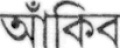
আঁকিব
